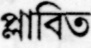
প্লাবিত
